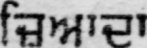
ਜ਼ਿਆਦਾ
